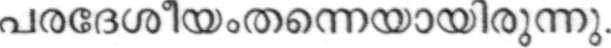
പരദേശീയംതന്നെയായിരുന്നു.
